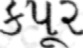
કપૂર
